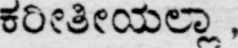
ಕರೀತೀಯಲ್ಲಾ,
